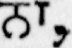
ਨਾ,
